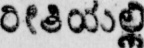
ರೀತಿಯಲ್ಲಿ
